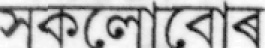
সকলোবোৰ
